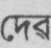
দেৱ
